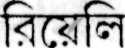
রিয়েলি
